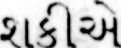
શકીએ
